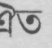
ঐত
